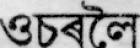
ওচৰলৈ
